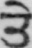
ਤੇ
